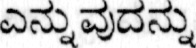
ಎನ್ನುವುದನ್ನು
